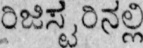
ರಿಜಿಸ್ಟರಿನಲ್ಲಿ
